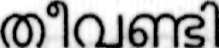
തീവണ്ടി
